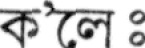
ক'লেঃ
